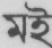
মই
